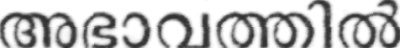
അഭാവത്തില്‍
